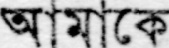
আমাকে
